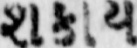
શકાય
